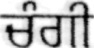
ਚੰਗੀ
